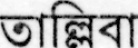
তাল্লিবা
